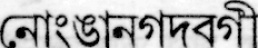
নোংঙানগদবগী
